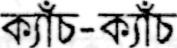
ক্যাঁচ-ক্যাঁচ
